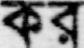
কর
